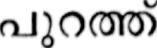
പുറത്ത്
